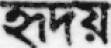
হৃদয়
